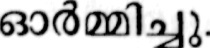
ഓര്‍മ്മിച്ചു.
